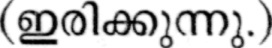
(ഇരിക്കുന്നു.)
